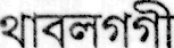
থাবলগী
